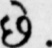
છે.
